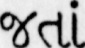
જતાં
